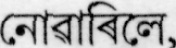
নোৱাৰিলে,
